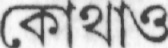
কোথাও
